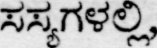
ಸಸ್ಯಗಳಲ್ಲಿ,
